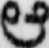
ಆ
